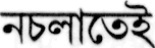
নচলাতেই
